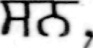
ਸਨ,
